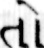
તો
